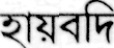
হায়বদি
